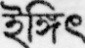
ইঙ্গিৎ
